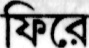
ফিরে
